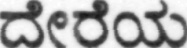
ದೇರೆಯ
